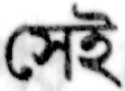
সেই
